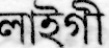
লাইগী
